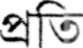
প্রতি
